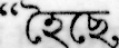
"হৈছে,
